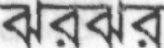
ঝরঝর
